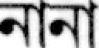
নানা
